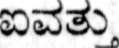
ಐವತ್ತು
